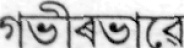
গভীৰভাৱে
